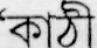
'কাঠী
